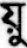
য়ু
